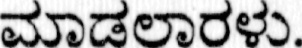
ಮಾಡಲಾರಳು.
